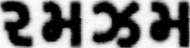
રમઝમ
